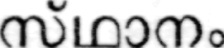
സ്ഥാനം
